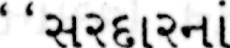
"સરદારનાં
